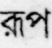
রূপ
